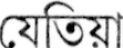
যেতিয়া
